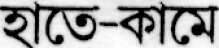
হাতে-কামে
